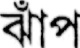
ঝাঁপ
